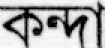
কন্দা
